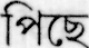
পিছে
